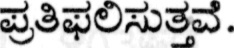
ಪ್ರತಿಫಲಿಸುತ್ತವೆ.
